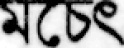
মচেৎ
